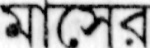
মাসের
